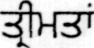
ਤ੍ਰੀਮਤਾਂ
